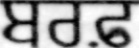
ਬਰਫ਼
